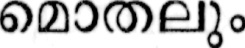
മൊതലും
